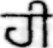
ਹੀ
